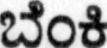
ಬೆಂಕಿ
